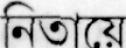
নিতায়ে
